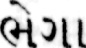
ભેગા
